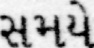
સમયે
